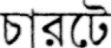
চারটে
